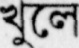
খুলে
